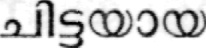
ചിട്ടയായ
